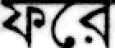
ফরে
